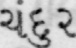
ચંદુર
